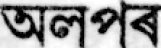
অলপৰ
